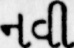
નવી
